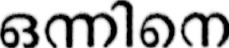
ഒന്നിനെ
